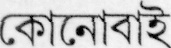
কোনোবাই
